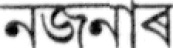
নজনাৰ
